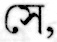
সে,
